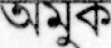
অমুক
